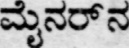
ಮೈನರ್‌ನ
